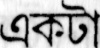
একটা
